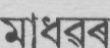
মাধৱৰ
